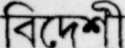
বিদেশী
